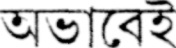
অভাবেই
